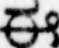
ಈ
